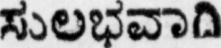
ಸುಲಭವಾಗಿ
